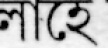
লাহে
